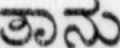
ತಾನು
